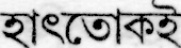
হাৎতোকই
